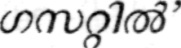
ഗസറ്റില്‍'
